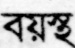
বয়স্থ
